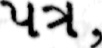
પત્ર,
